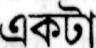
একটা
